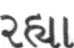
રહ્યા
